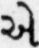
એ
